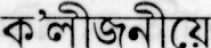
ক'লীজনীয়ে
